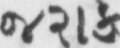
જરાક
